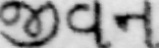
જીવન
